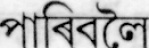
পাৰিবলৈ
